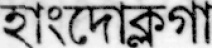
হাংদোক্লগা
